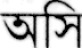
অসি
